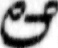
ಆ
